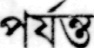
পর্যন্ত
